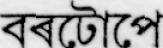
বৰটোপে
